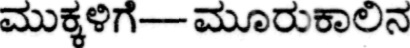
ಮುಕ್ಕಳಿಗೆ-ಮೂರುಕಾಲಿನ
